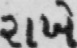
રાખે
